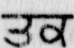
ਤਕ
